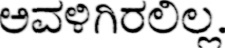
ಅವಳಿಗಿರಲಿಲ್ಲ.
